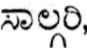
ಸಾಲ್ಗರಿ,
